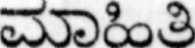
ಮಾಹಿತಿ
